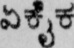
ಏಕೈಕ
